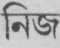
নিজ
